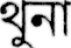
থুনা
